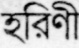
হরিণী
